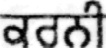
ਕਰਨੀ
